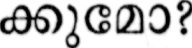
ക്കുമോ?
